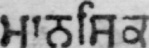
ਮਾਨਸਿਕ
